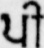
ਪੀ
